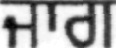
ਜਾਗ
